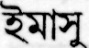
ইমাসু
